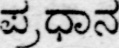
ಪ್ರಧಾನ
